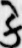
કે
